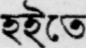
হইতে
